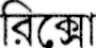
রিক্সো
